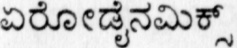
ಏರೋಡೈನಮಿಕ್ಸ್
